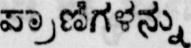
ಪ್ರಾಣಿಗಳನ್ನು
